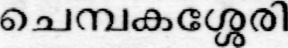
ചെമ്പകശ്ശേരി
